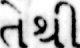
તેથી
